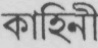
কাহিনী
